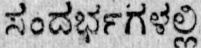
ಸಮ್ದರ್ಭಗಳಲ್ಲಿ
